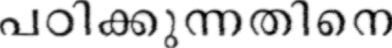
പഠിക്കുന്നതിനെ
